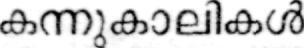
കന്നുകാലികള്‍
